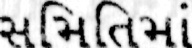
સમિતિમાં
